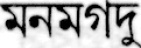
মনমগদু
